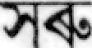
সৰু
